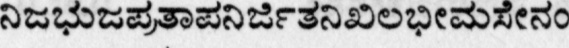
ನಿಜಭುಜಪ್ರತಾಪನಿರ್ಜಿತನಿಖಿಲಭೀಮಸೇನಂ
